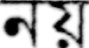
নয়
